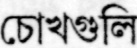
চোখগুলি
